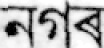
নগৰ
